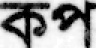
কপ
